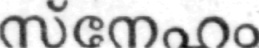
സ്നേഹം
